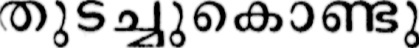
തുടച്ചുകൊണ്ടു
